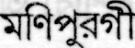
মণিপুরগী
